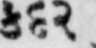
કદર
